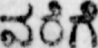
ವರೆಗೆ
